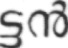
ട്ടന്‍
